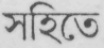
সহিতে
